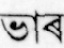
ভাৰ
